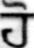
ਹੋ
